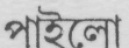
পাইলো
